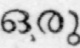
ഒരു
